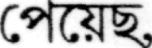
পেয়েছ,
